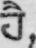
ਹੈ,
